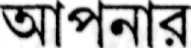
আপনার
